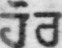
ਹੋਰ
